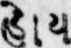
હોય
